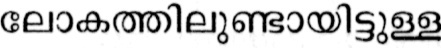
ലോകത്തിലുണ്ടായിട്ടുള്ള
